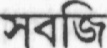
সবজি
